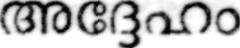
അദ്ദേഹം
